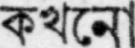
কখনো
